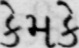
કેમકે
